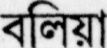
বলিয়া
